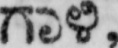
ಗಾಳಿ,
